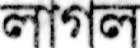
লাগল
